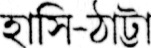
হাসি-ঠাট্টা
